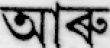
আৰু
